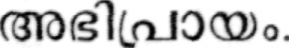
അഭിപ്രായം.
